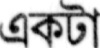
একটা
